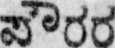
ಪೌರರ
